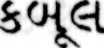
કબૂલ
